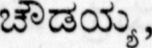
ಚೌಡಯ್ಯ,
